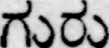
ಗುರು
